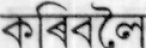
কৰিবলৈ
